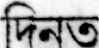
দিনত
